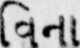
વિના
